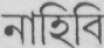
নাহিবি
